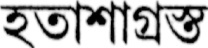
হতাশাগ্রস্ত
